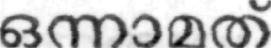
ഒന്നാമത്
